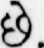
છે.
